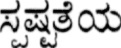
ಸ್ಪಷ್ಟತೆಯ
